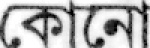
কোনো
